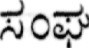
ಸಂಘ
